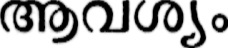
ആവശ്യം
